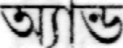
অ্যান্ড
